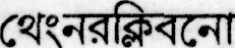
থেংনরক্লিবনো
